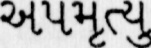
અપમૃત્યુ
